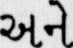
અને
